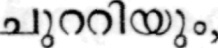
ചുററിയും,
